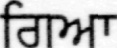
ਗਿਆ
